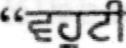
''ਵਹੁਟੀ
